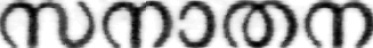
സനാതന
